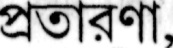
প্রতারণা,
